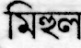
মিহুল
